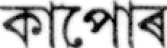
কাপোৰ
